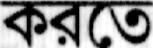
করতে
